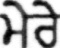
ਮੇਰੇ
